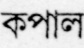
কপাল
